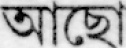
আছো
